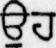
ਉਹ
